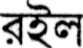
রইল
